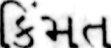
કિંમત
